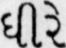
ધીરે
